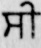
ਸੀ
